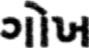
ગોખ
